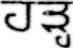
ਹੜ੍ਹ
